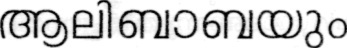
ആലിബാബയും
